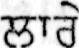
ਲਾਰੇ
